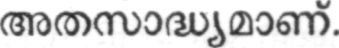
അതസാദ്ധ്യമാണ്.
